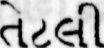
તેટલી
